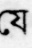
যে
